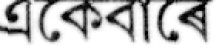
একেবাৰে
